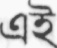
এই
